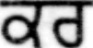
ਕਰ
